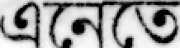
এনেতে
